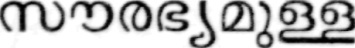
സൌരഭ്യമുള്ള
